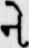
ને
